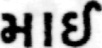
માઈ
